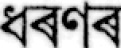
ধৰণৰ
